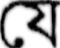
যে
